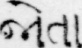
જોતા
